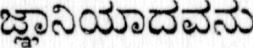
ಜ್ಞಾನಿಯಾದವನು
